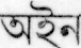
অইন
